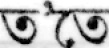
ত'তে
